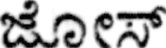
ಜೋಸ್
